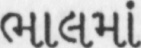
ભાલમાં
